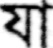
যা
